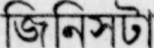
জিনিসটা
